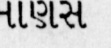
માણસ
